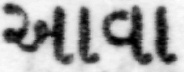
આવા
